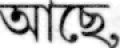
আছে,
